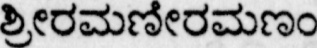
ಶ್ರೀರಮಣೀರಮಣಂ
